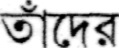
তাঁদের
